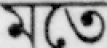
মতে
